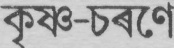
কৃষ্ণ-চৰণে
